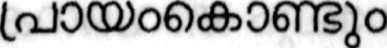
പ്രായംകൊണ്ടും
